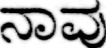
ನಾವು
